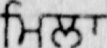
ਮਿਲਾ
